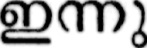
ഇന്നു
